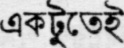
একটুতেই
